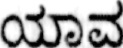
ಯಾವ
